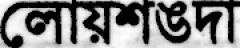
লোযশঙদা
